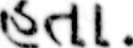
હતા.
